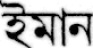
ইমান
